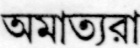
অমাত্যরা
